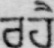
ਰਹੈ
